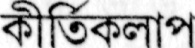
কীর্তিকলাপ
